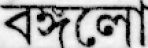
বঙ্গলো
